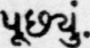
પૂછ્યું.
